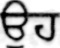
ਉਹ
